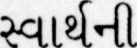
સ્વાર્થની
